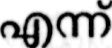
എന്ന്
